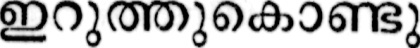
ഇറുത്തുകൊണ്ടു
